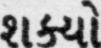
શક્યો
